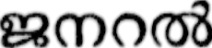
ജനറല്‍
